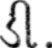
ડી.
